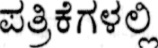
ಪತ್ರಿಕೆಗಳಲ್ಲಿ
